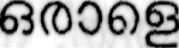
ഒരാളെ
